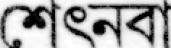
শেৎনবা
